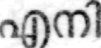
എനി
